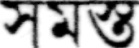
সমস্ত
